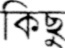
কিছু
